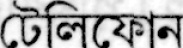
টেলিফোন
